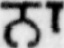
ਨਾ
